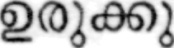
ഉരുക്കു
